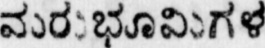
ಮರುಭೂಮಿಗಳ
